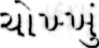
ચોખ્ખું
